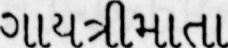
ગાયત્રીમાતા
